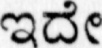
ಇದೇ
